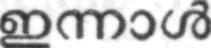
ഇന്നാള്‍
